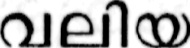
വലിയ
